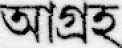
আগ্ৰহ
